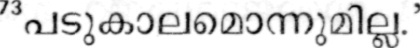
73പടുകാലമൊന്നുമില്ല.'
